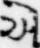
એ
